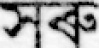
সৰু
